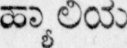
ಹ್ಯಾಲಿಯ
